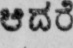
ಆದರೆ
